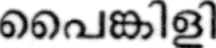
പൈങ്കിളി
